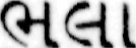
ભલા
